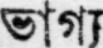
ভাগ্য
